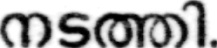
നടത്തി.
